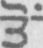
ਤੋਂ
